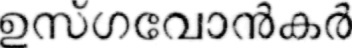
ഉസ്ഗവോന്‍കര്‍
